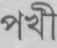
পখী
